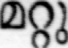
മറ്റു
